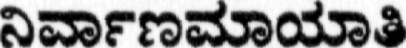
ನಿರ್ವಾಣಮಾಯಾತಿ
